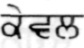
ਕੇਵਲ
